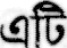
এটি
